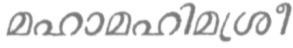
മഹാമഹിമശ്രീ
